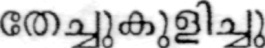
തേച്ചുകുളിച്ചു
